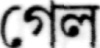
গেল
